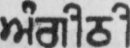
ਅੰਗੀਠੀ
